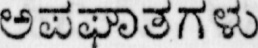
ಅಪಘಾತಗಳು
